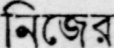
নিজের
